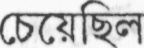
চেয়েছিল
